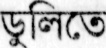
ডুলিতে
